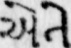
એને
